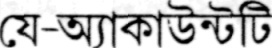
যে-অ্যাকাউন্টটি
